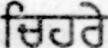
ਚਿਹਰੇ
